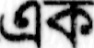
এক
